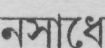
নসাধে
